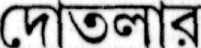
দোতলার
